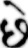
છે
